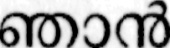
ഞാന്‍
